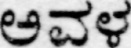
ಅವಳ
